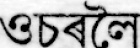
ওচৰলৈ
